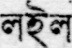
লইল
